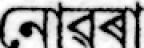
নোৱৰা
